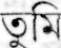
তুমি
